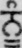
ਨੂੰ
